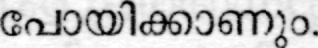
പോയിക്കാണും.
